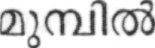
മുമ്പില്‍
